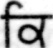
ਕਿ
